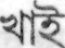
খাই
